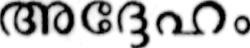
അദ്ദേഹം
